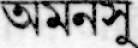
অমনসু
